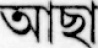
আছা
